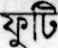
ফুটি
